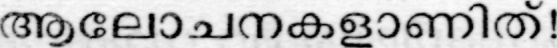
ആലോചനകളാണിത്!
